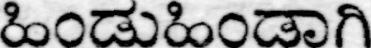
ಹಿಂಡುಹಿಂಡಾಗಿ
